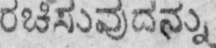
ರಚಿಸುವುದನ್ನು
